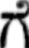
ಗೆ
